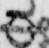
ಈ
